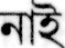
নাই
